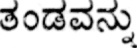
ತಂಡವನ್ನು
